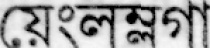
য়েংলম্লগা
